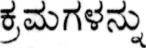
ಕ್ರಮಗಳನ್ನು
